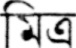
মিত্র
